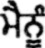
ਮੈਨੂੰ
